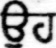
ਉਹ
